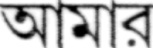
আমার
